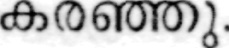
കരഞ്ഞു.
